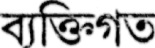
ব্যক্তিগত
